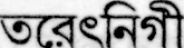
তরেৎনিগী
